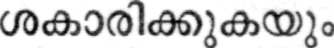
ശകാരിക്കുകയും
